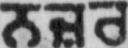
ਨਜ਼ਰ
